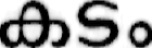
കടം
